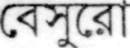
বেসুরো
